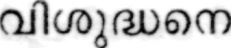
വിശുദ്ധനെ
